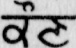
ਕੌਣ
